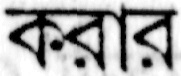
করার
